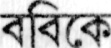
ববিকে
